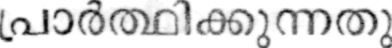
പ്രാര്‍ത്ഥിക്കുന്നതു
